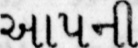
આપની
